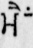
ਮੈਂ
